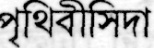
পৃথিবীসিদা
